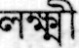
লক্ষ্মী
